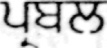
ਪ੍ਰਬਲ
